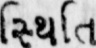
સ્થિતિ
